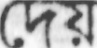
দেয়
